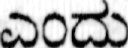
ಎಂದು
